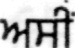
ਅਸੀਂ
